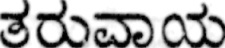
ತರುವಾಯ
